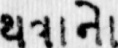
થવાનો
